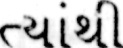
ત્યાંથી
